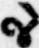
જે
